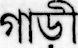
গাড়ী
